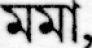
মমা,
